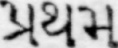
પ્રથમ
